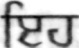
ਇਹ
